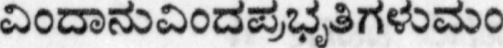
ವಿಂದಾನುವಿಂದಪ್ರಭೃತಿಗಳುಮಂ
